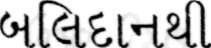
બલિદાનથી
